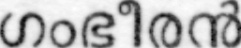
ഗംഭീരന്‍
